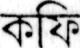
কফি
